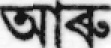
আৰু
